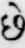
છે
